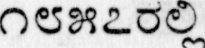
೧೮೫೭ರಲ್ಲಿ
